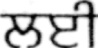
ਲਈ
